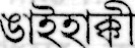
ঙাইহাক্কী
